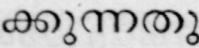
ക്കുന്നതു
